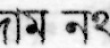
দাম নথ
